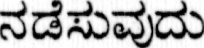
ನಡೆಸುವುದು
